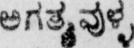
ಅಗತ್ಯವುಳ್ಳ
